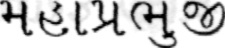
મહાપ્રભુજી
